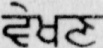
ਵੇਖਣ
